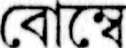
বোম্বে
